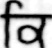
ਕਿ
